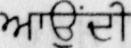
ਆਉਂਦੀ
